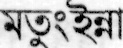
মতুংইন্না
